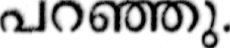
പറഞ്ഞു.
